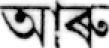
আৰু
